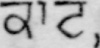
ਕਾਟ,
